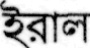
ইরাল
